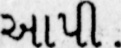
આપી.
